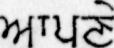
ਆਪਣੇ
